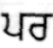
ਪਰ
